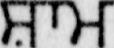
ਸ਼ਾਮ
